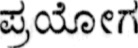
ಪ್ರಯೋಗ
